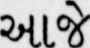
આજે
